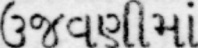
ઉજવણીમાં
